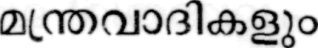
മന്ത്രവാദികളും
